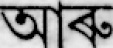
আৰু
